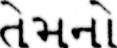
તેમનો
